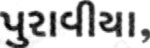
પુરાવાયા,
